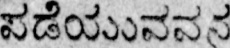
ಪದೆಯುವವನ
